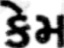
કેમ
